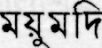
ময়ুমদি
